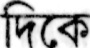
দিকে
